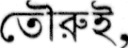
তৌরুই,
